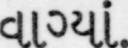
વાગ્યાં.
